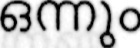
ഒന്നും
